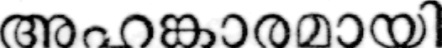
അഹങ്കാരമായി
